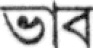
ভাব
